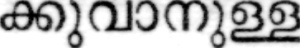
ക്കുവാനുള്ള
